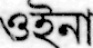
ওইনা
